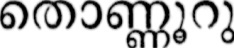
തൊണ്ണൂറു
